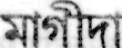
মাগীদা
